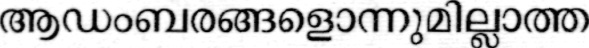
ആഡംബരങ്ങളൊന്നുമില്ലാത്ത
